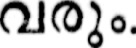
വരും.
